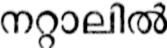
നറ്റാലില്‍
